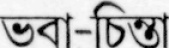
ভবা-চিন্তা
